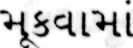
મૂકવામાં
